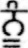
ਨੂੰ
